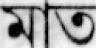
মাত
